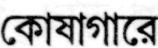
কোষাগারে
